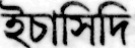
ইচাসিদি
